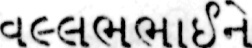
વલ્લભભાઈને
